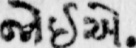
જોઈએ.
